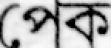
পেক
